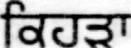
ਕਿਹੜਾ
